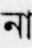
না
